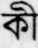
কী
